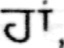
ਹਾਂ,
